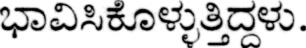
ಭಾವಿಸಿಕೊಳ್ಳುತ್ತಿದ್ದಳು.
